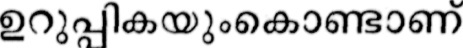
ഉറുപ്പികയുംകൊണ്ടാണ്
